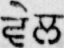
ਵੇਲ
